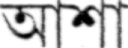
আশা
